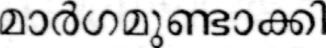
മാര്‍ഗമുണ്ടാക്കി
